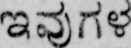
ಇವುಗಳ
